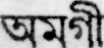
অমগী
